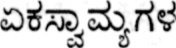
ಏಕಸ್ವಾಮ್ಯಗಳ
